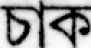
চাক
